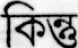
কিন্তু
